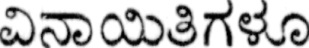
ವಿನಾಯಿತಿಗಳೂ
